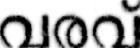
വരവ്
